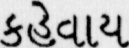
કહેવાય
